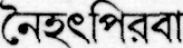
নৈহৎপিরবা
